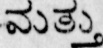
ಮತ್ತು
